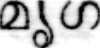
മൃഗ
